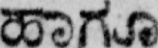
ಹಾಗೂ
